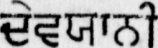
ਦੇਵਯਾਨੀ
